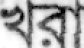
খরা
